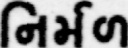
નિર્મળ
